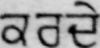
ਕਰਦੇ
